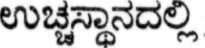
ಉಚ್ಚಸ್ಥಾನದಲ್ಲಿ
